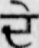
ਦੇ
